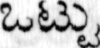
ಒಟ್ಟು
